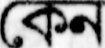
কেন
